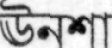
ঊনশা
